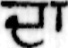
ਦਾ
